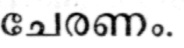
ചേരണം.
